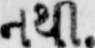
નથી.
